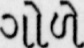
ગોળે
